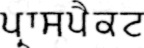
ਪ੍ਰਾਸਪੈਕਟ
